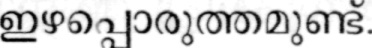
ഇഴപ്പൊരുത്തമുണ്ട്.
